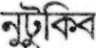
নুটুকিব
